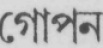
গোপন
